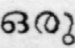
ഒരു
